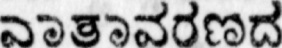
ವಾತಾವರಣದ
